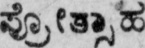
ಪ್ರೋತ್ಸಾಹ
